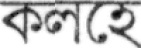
কলহে
